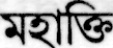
মহাক্তি
